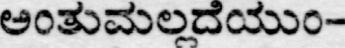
ಅಂತುಮಲ್ಲದೆಯುಂ
